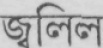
জ্বলিল
